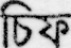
চিফ
